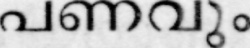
പണവും
